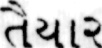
તૈયાર
